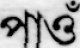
পাওঁ
